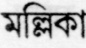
মল্লিকা
